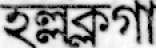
হল্লক্লগা
